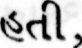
હતી,
